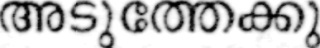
അടുത്തേക്കു
